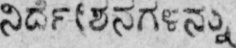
ನಿರ್ದೇಶನಗಳನ್ನು
